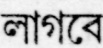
লাগবে
